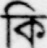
কি
